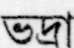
ভদ্রা
